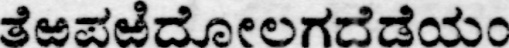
ತೆಱಪಱದೋಲಗದೆಡೆಯಂ
